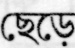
ছেড়ে
